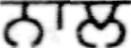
ਨਾਲ
